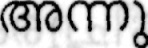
അന്നു
